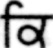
ਕਿ
